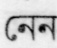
নেন
